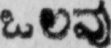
ಒಲವು
